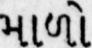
માળો
